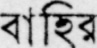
বাহির
